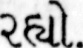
રહ્યો.
